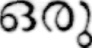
ഒരു
